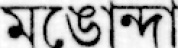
মঙোন্দা
